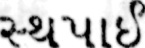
સ્થપાઈ
